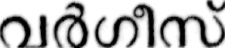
വര്‍ഗീസ്
